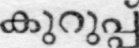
കുറുപ്പ്
